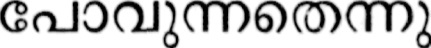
പോവുന്നതെന്നു
